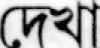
দেখা
